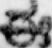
ಈ
